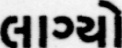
લાગ્યો
